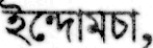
ইন্দোমচা,
